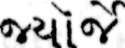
જ્યૉર્જે
